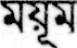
ময়ূম
